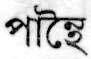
পান্থৈ
